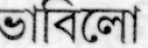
ভাবিলো
